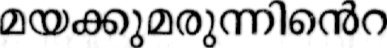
മയക്കുമരുന്നിന്റെ
